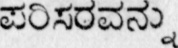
ಪರಿಸರವನ್ನು
